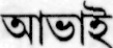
আভাই
